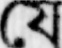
যে
